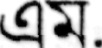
এম.
